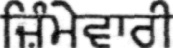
ਜ਼ਿੰਮੇਵਾਰੀ
